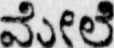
ಮೇಲೆ
